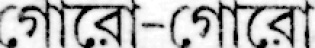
গোরো-গোরো
